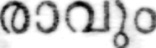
രാവും
